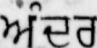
ਅੰਦਰ
